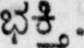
ಭಕ್ತಿ.
